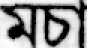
মচা
